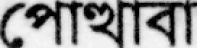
পোত্থাবা
